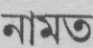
নামত
